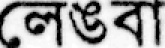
লেঙবা
